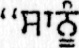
''ਸਾਨੂੰ
